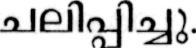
ചലിപ്പിച്ചു.
